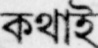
কথাই
